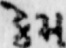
કેમ
